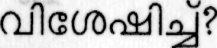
വിശേഷിച്ച്?
